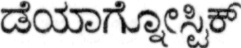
ಡೆಯಾಗ್ನೋಸ್ಟಿಕ್
